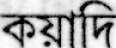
কয়াদি
